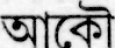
আকৌ
